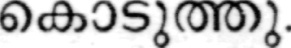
കൊടുത്തു.
